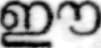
ഈ
